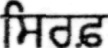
ਸਿਰਫ਼
